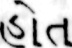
હોત
